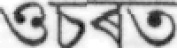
ওচৰত
